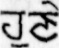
ਹੁਣੇ
